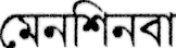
মেনশিনবা
